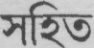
সহিত
